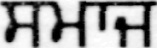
ਸਮਾਜ
